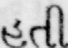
હતી
